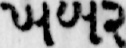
ખબર
